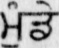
ਮੁੰਡੇ
